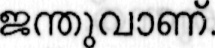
ജന്തുവാണ്.
